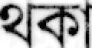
থকা
